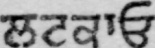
ਲਟਕਾਓ
